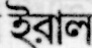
ইরাল
